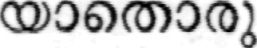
യാതൊരു
